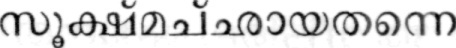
സൂക്ഷ്മച്ഛായതന്നെ
